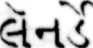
લૅનર્ડે
